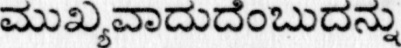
ಮುಖ್ಯವಾದುದೆಂಬುದನ್ನು
